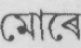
মোৰে
